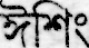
ঈশিং
